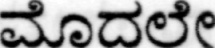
ಮೊದಲೇ
